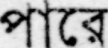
পারে
